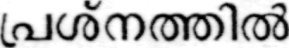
പ്രശ്നത്തില്‍
